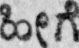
ಹೀಗೆ
